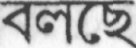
বলছে
